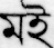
মই
